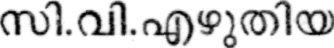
സി.വി.എഴുതിയ
